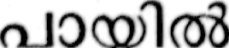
പായില്‍
